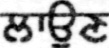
ਲਾਉਣ
